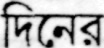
দিনের
